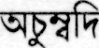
অচুম্বদি
